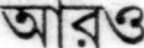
আরও
